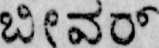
ಬೀವರ್
